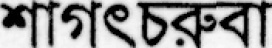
শাগৎচরুবা
